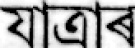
যাত্রাৰ
